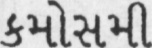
કમોસમી
